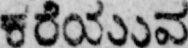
ಕರೆಯುವ
